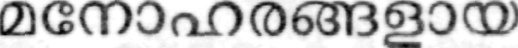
മനോഹരങ്ങളായ
